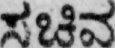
ಸಚಿವ
